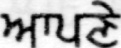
ਆਪਣੇ
